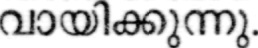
വായിക്കുന്നു.
